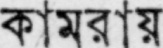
কামরায়
